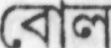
বোল
